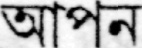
আপন
